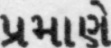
પ્રમાણે
